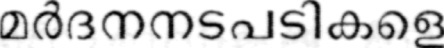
മര്‍ദനനടപടികളെ
